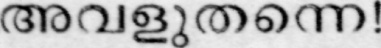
അവളുതന്നെ!
